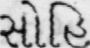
સોહિ
